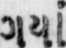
ગયાં
